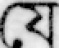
যে
